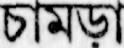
চামড়া
